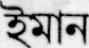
ইমান
